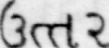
ઉત્તર
